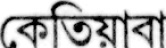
কেতিয়াবা
